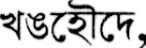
খঙহৌদে,
